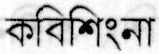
কবিশিংনা
